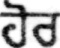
ਹੋਰ
